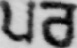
ਪਰ
